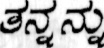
ತನ್ನನ್ನು
